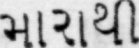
મારાથી
